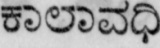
ಕಾಲಾವಧಿ
